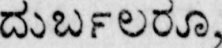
ದುರ್ಬಲರೂ,
